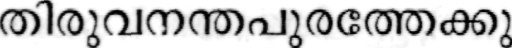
തിരുവനന്തപുരത്തേക്കു
